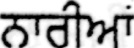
ਨਾਰੀਆਂ
